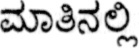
ಮಾತಿನಲ್ಲಿ
